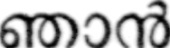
ഞാന്‍
